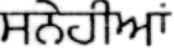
ਸਨੇਹੀਆਂ
